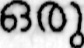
ഒരു
